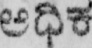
ಅಧಿಕ
